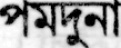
পমদুনা
